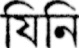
যিনি
